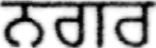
ਨਗਰ
